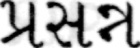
પ્રસન્ન
